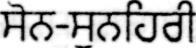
ਸੋਨ-ਸੁਨਹਿਰੀ
